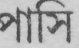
পাসি
